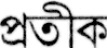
প্রতীক
